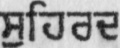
ਸੁਹਿਰਦ
